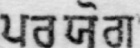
ਪਰਯੋਗ
